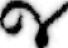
જ
